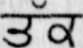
ਤੱਕ
